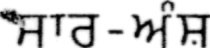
ਸਾਰ-ਅੰਸ਼
